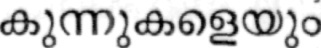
കുന്നുകളെയും
